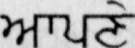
ਆਪਣੇ
